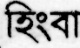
হিংবা
